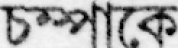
চম্পাকে
